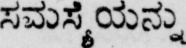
ಸಮಸ್ಯೆಯನ್ನು
